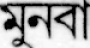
মুনবা
